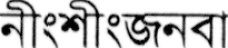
নীংশীংজনবা
